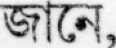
জানে,
